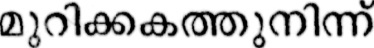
മുറിക്കകത്തുനിന്ന്
